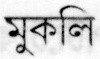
মুকলি
